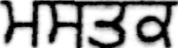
ਮਸਤਕ
